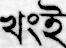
খংই
